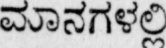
ಮಾನಗಳಲ್ಲಿ
